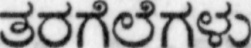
ತರಗಲೆಗಳು
